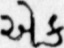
એક
